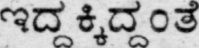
ಇದ್ದಕ್ಕಿದ್ದಂತೆ
